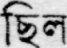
ছিল
